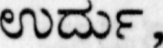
ಉರ್ದು,
